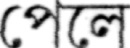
পেলে
